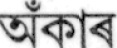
অঁকাৰ
